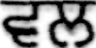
ਵਲ
